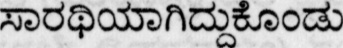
ಸಾರಥಿಯಾಗಿದ್ದುಕೊಂಡು
